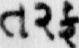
તરફ
